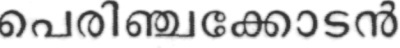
പെരിഞ്ചക്കോടന്‍
